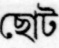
ছোট
